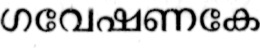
ഗവേഷണകേ
